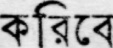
করিবে
